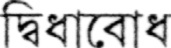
দ্বিধাবোধ
